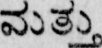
ಮತ್ತು
